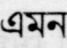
এমন
